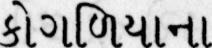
કોગળિયાના
